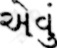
એવું
